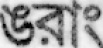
ঙরাং
